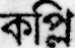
কপ্লি
